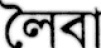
লৈবা
